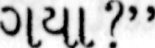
ગયા?"
